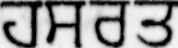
ਹਸਰਤ
